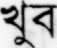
খুব
